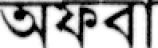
অফবা
